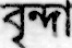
বৃন্দা
